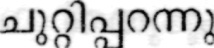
ചുറ്റിപ്പറന്നു
